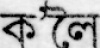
ক'লৈ
